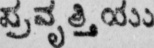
ಪ್ರವೃತ್ತಿಯು
